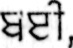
ਬਈ,
